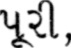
પૂરી,
